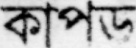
কাপড়
